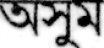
অসুম
